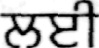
ਲਈ
